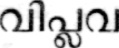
വിപ്ലവ
